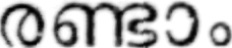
രണ്ടാം
